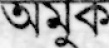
অমুক
